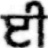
ਈ
